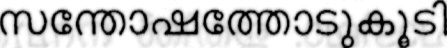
സന്തോഷത്തോടുകൂടി
